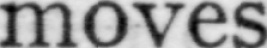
moves
